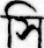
সে
